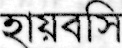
হায়বসি
